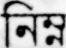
নিম্ন
